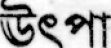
ঊৎপা
